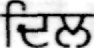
ਦਿਲ
